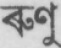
ৰুণু
